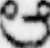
ಆ
